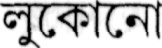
লুকোনো
